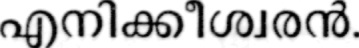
എനിക്കീശ്വരന്‍.
